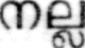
നല്ല
